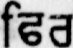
ਫਿਰ
